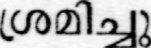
ശ്രമിച്ചു
